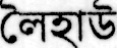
লৈহাউ
